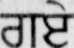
ਗਏ
